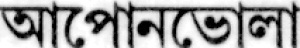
আপোনভোলা
